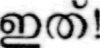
ഇത്!
